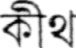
কীথ
